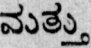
ಮತ್ತು
